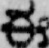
ಈ
